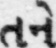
તને
